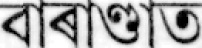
বাৰাণ্ডাত
